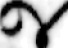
જ
